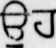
ਉਹ
